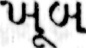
ખૂબ
